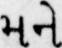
મને
